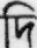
দি
